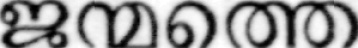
ജന്മത്തെ
